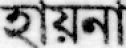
হায়না
